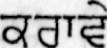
ਕਰਾਵੇ
